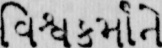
વિશ્વકર્માને
